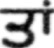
ਤਾਂ
